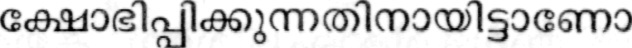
ക്ഷോഭിപ്പിക്കുന്നതിനായിട്ടാണോ
